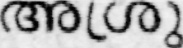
അശ്രു
